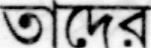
তাদের
